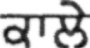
ਕਾਲੇ
